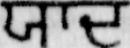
ਯਾਦ
